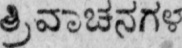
ತ್ರಿವಾಚನಗಳ
